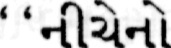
"નીચેનો
